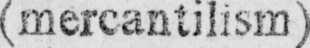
(mercantilism)
